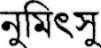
নুমিৎসু
